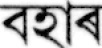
বহাৰ
